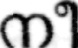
നീ
